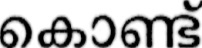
കൊണ്ട്
